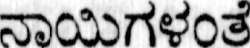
ನಾಯಿಗಳಂತೆ
